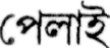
পেলাই
